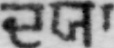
ਦਯਾ
